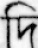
দি
